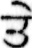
ਤੇ
